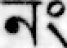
নং
